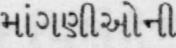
માંગણીઓની
